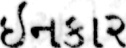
ઇનકાર
